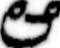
ಆ
